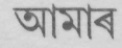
আমাৰ
